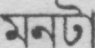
মনটা
